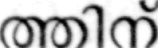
ത്തിന്
